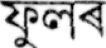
ফুলৰ
